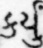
કર્યું
